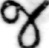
જ
